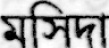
মসিদা
